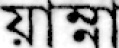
য়াম্না
